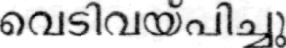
വെടിവയ്പിച്ചു
